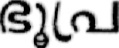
ഭൂപ്ര
